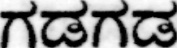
ಗಡಗಡ
